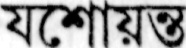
যশোয়ন্ত
